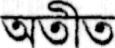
অতীত
